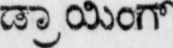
ಡ್ರಾಯಿಂಗ್
